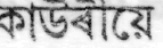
কাউৰীয়ে
